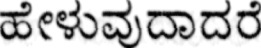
ಹೇಳುವುದಾದರೆ
